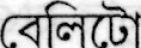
বেলিটো
